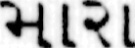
મારા
